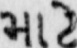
માટે
